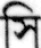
সি
